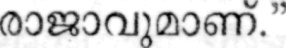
രാജാവുമാണ്.”
